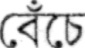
বেঁচে
